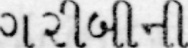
ગરીબીની
